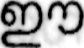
ഈ
